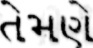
તેમણે
